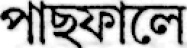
পাছফালে
